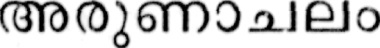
അരുണാചലം
